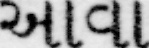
આવા
